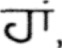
ਹਾਂ,
